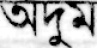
অদুম
